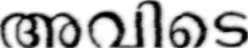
അവിടെ
